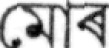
মোৰ
